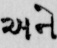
અને
